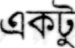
একটু
